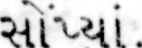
સોંપ્યાં.
